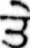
ਤੇ
